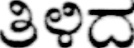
ತಿಳಿದ
